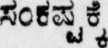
ಸಂಕಷ್ಟಕ್ಕೆ
